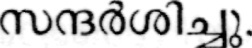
സന്ദര്‍ശിച്ചു.
